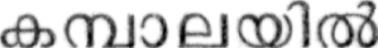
കമ്പാലയില്‍
